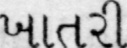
ખાતરી
